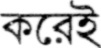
করেই
